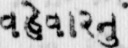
વહેવારનું
